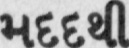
મદદથી
